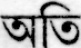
অতি
